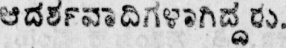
ಆದರ್ಶವಾದಿಗಳಾಗಿದ್ದರು.
